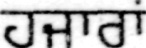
ਹਜਾਰਾਂ
